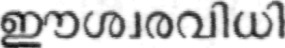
ഈശ്വരവിധി
